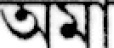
অমা
